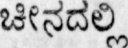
ಚೀನದಲ್ಲಿ
